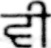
ਵੀ
